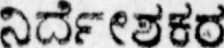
ನಿರ್ದೇಶಕರ
